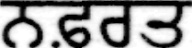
ਨਫ਼ਰਤ
